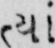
ત્યાં
